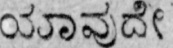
ಯಾವುದೇ
